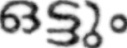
ഒട്ടും
